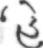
'હે
